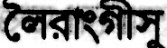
লৈরাংগীসু
